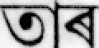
তাৰ
